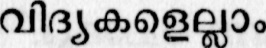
വിദ്യകളെല്ലാം
